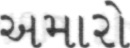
અમારો
